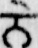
ਨੇ
